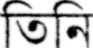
তিনি
